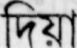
দিয়া
